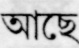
আছে
